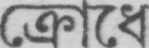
ক্রোধে
